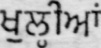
ਖੁਲ੍ਹੀਆਂ
